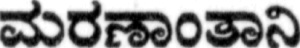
ಮರಣಾಂತಾನಿ
